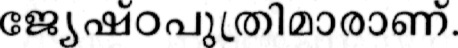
ജ്യേഷ്ഠപുത്രിമാരാണ്.
